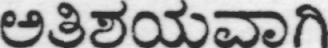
ಅತಿಶಯವಾಗಿ
